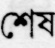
শেষ
